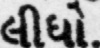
લીધો.
